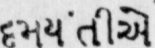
દમયંતીએ
